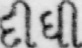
દીધી
